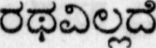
ರಥವಿಲ್ಲದೆ
